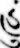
હું
